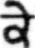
ਕੇ
